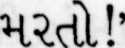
મરતો!'
